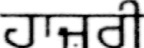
ਹਾਜ਼ਰੀ
